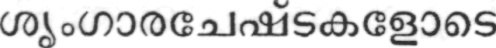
ശൃംഗാരചേഷ്ടകളോടെ
